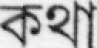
কথা
